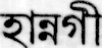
হান্নগী
